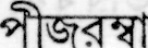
পীজরম্বা
